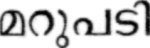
മറുപടി
